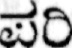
ಪರಿ
